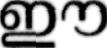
ഈ
